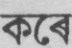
কৰে
